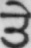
ਤੇ
